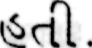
હતી.
